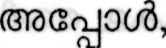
അപ്പോള്‍,
